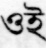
ওই
